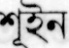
শূইন
